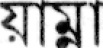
য়াম্না
